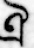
ঐ
